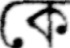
কে
